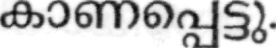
കാണപ്പെട്ടു.
